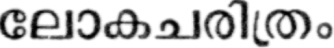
ലോകചരിത്രം
